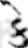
કે
